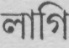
লাগি
